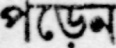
পড়েন
